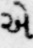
એ
